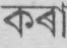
কৰা
